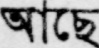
আছে
